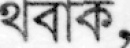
থবাক,
